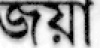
জয়া
